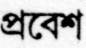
প্রবেশ
